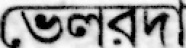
ভেলরদা
